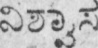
ವಿಶ್ವಾಸ
